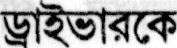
ড্রাইভারকে
